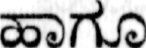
ಹಾಗೂ
